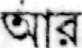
আর
